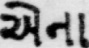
એના
